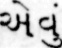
એવું
